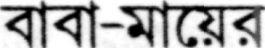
বাবা-মায়ের
